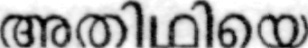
അതിഥിയെ
